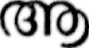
ആ
